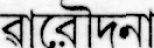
ৱারৌদনা
